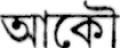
আকৌ
